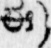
ಈ)
